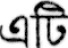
এটি
